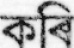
কৰি
